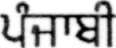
ਪੰਜਾਬੀ
